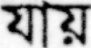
যায়
